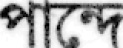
পান্দে
